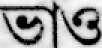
ভাও
